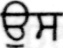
ਉਸ
